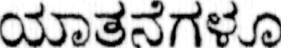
ಯಾತನೆಗಳೂ
